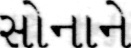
સોનાને
